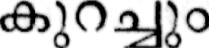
കുറച്ചും
